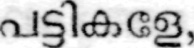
പട്ടികളേ,
